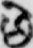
છે
